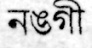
নঙগী
